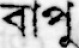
বাপু
